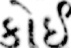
કોઈ
